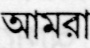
আমরা
